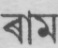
ৰাম
